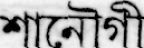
শানৌগী
